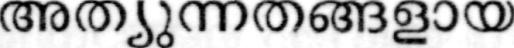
അത്യുന്നതങ്ങളായ
